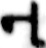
ન
